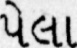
પેલા
